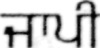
ਜਾਪੀ
